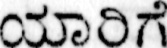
ಯಾರಿಗೆ
